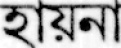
হায়না
